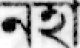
নহা
